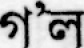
গ'ল
